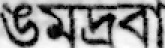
ঙমদ্রবা
